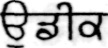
ਉਡੀਕ
